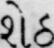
શેઠ
